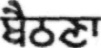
ਬੈਠਣਾ
